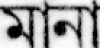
মানা
